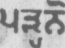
ਪੜ੍ਹਨੋ
